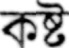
কষ্ট
